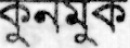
কুনমুক
